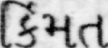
કિંમત
